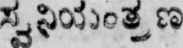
ಸ್ವನಿಯಂತ್ರಣ
